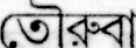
তৌরুবা
